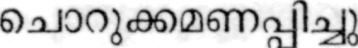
ചൊറുക്കമണപ്പിച്ചു
